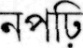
নপঢ়ি
